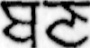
ਬਣ
